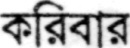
করিবার
